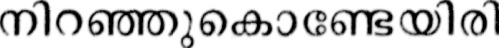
നിറഞ്ഞുകൊണ്ടേയിരി
